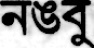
নঙবু
